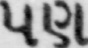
પણ
